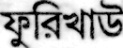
ফুরিখাউ
